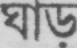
ঘাড়
